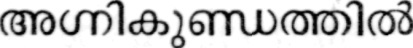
അഗ്നികുണ്ഡത്തില്‍
